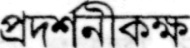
প্রদর্শনীকক্ষ
